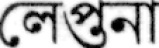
লেপ্তনা
